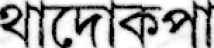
থাদোকপা
